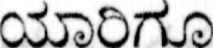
ಯಾರಿಗೂ
